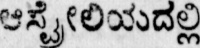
ಆಸ್ಟ್ರೇಲಿಯದಲ್ಲಿ
